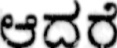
ಆದರೆ
